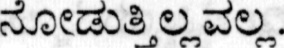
ನೋಡುತ್ತಿಲ್ಲವಲ್ಲ.
